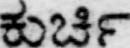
ಕುರ್ಚಿ
